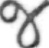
જ
